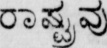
ರಾಷ್ಟ್ರವು
